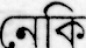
নেকি
